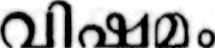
വിഷമം
